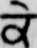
ਕੇ
